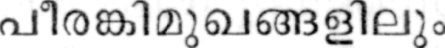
പീരങ്കിമുഖങ്ങളിലും
